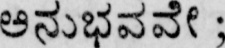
ಅನುಭವವೇ;
